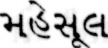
મહેસૂલ
